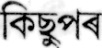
কিছুপৰ
